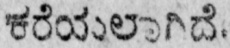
ಕರೆಯಲಾಗಿದೆ.
